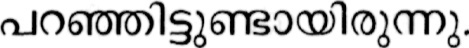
പറഞ്ഞിട്ടുണ്ടായിരുന്നു.
